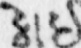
કોઈ
